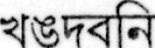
খঙদবনি
